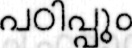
പഠിപ്പും
